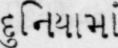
દુનિયામાં
